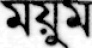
ময়ুম
